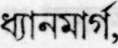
ধ্যানমার্গ,
